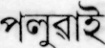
পলুৱাই
